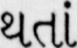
થતાં
